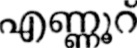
എണ്ണൂറ്
